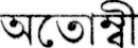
অতোম্বী
